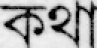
কথা
